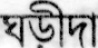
ঘড়ীদা
